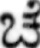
ಚೆ
